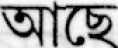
আছে
